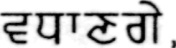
ਵਧਾਣਗੇ,
